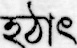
হঠাৎ
